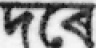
দৰে
